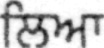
ਲਿਆ
